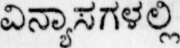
ವಿನ್ಯಾಸಗಳಲ್ಲಿ
